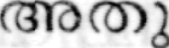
അതു
